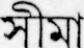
সীমা
